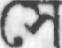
সে
